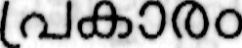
പ്രകാരം
